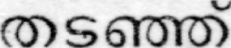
തടഞ്ഞ്
